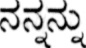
ನನ್ನನ್ನು
